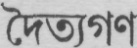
দৈত্যগণ
